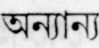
অন্যান্য
